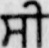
ਸੀ
